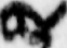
જ
